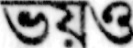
ভয়ও
